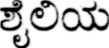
ಶೈಲಿಯ
